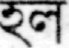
হল
